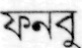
ফনবু
